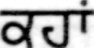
ਕਹਾਂ
